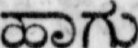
ಹಾಗು
